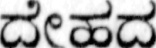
ದೇಹದ
